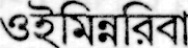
ওইমিন্নরিবা
